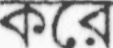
করে
